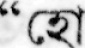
"হো
